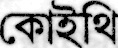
কোইথি
